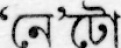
'নে'টো
